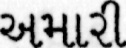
અમારી
